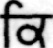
ਕਿ
